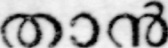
താന്‍
